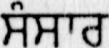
ਸੰਸਾਰ
